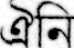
ঐনি
